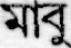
মাবু
